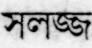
সলজ্জ
